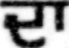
ਦਾ
